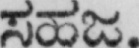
ಸಹಜ.
